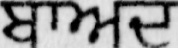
ਬਾਅਦ
